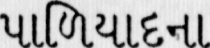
પાળિયાદના
